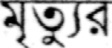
মৃত্যুর
